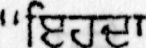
''ਇਹਦਾ
